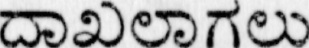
ದಾಖಲಾಗಲು
